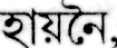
হায়নৈ,
